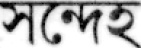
সন্দেহ
